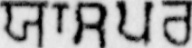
ਯਾਸਪਰ
